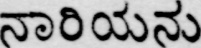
ನಾರಿಯನು
